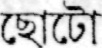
ছোটো
